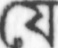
যে
